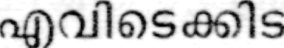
എവിടെക്കിട
